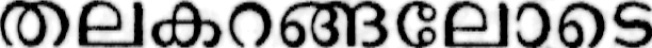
തലകറങ്ങലോടെ
